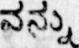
ವನ್ನು
